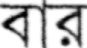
বার
